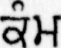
ਕੰਮ
